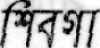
শিবগা
